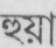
হুয়া
